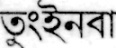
তুংইনবা
